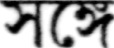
সঙ্গে
